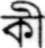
কী
